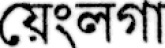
য়েংলগা
